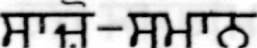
ਸਾਜ਼ੋ-ਸਮਾਨ
